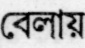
বেলায়
